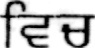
ਵਿਚ
